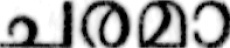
ചരമാ
